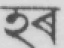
হৰ
